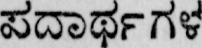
ಪದಾರ್ಥಗಳ
